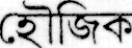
হৌজিক
